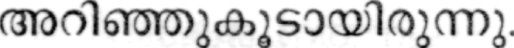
അറിഞ്ഞുകൂടായിരുന്നു.
